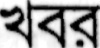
খবর
